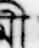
মী
